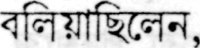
বলিয়াছিলেন,
